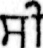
ਸੀ
